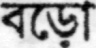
বড়ো
